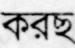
করছ
